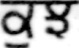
ਕੁਝ
